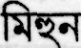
মিহুন
